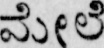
ಮೇಲೆ
